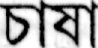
চাষা
